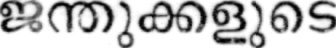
ജന്തുക്കളുടെ
